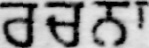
ਰਚਨਾ
